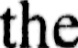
the
